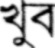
খুব
